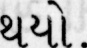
થયો.
